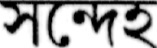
সন্দেহ
